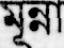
মূন্না
